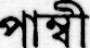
পাম্বী
